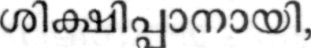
ശിക്ഷിപ്പാനായി,
